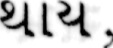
થાય,
